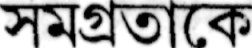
সমগ্রতাকে
